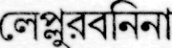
লেপ্লুরবনিনা
